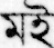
মই
